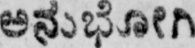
ಅನುಭೋಗಿ
